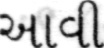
આવી
